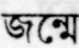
জন্মে
